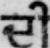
ਦੀ
